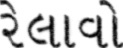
રેલાવો
